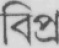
বিপ্র
